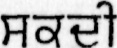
ਸਕਦੀ
